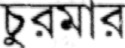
চুরমার
